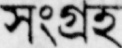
সংগ্রহ
